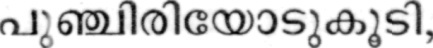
പുഞ്ചിരിയോടുകൂടി,
